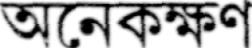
অনেকক্ষণ
